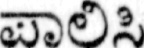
ಪಾಲಿಸಿ
